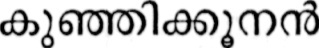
കുഞ്ഞിക്കൂനന്‍
